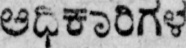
ಅಧಿಕಾರಿಗಳ
